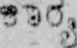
ಕಾರ್ಯ
